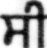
ਸੀ
